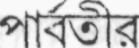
পার্বতীর
